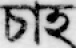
চাহ
